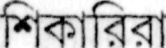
শিকারিরা
